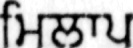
ਮਿਲਾਪ
